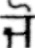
ਜੋ
